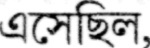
এসেছিল,
